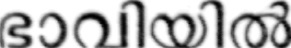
ഭാവിയില്‍
